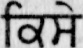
ਕਿਸੇ
